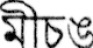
মীচঙ
